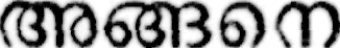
അങ്ങനെ
